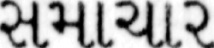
સમાચાર
